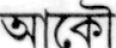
আকৌ
